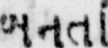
બનતાં
